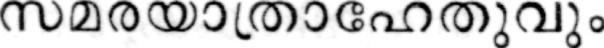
സമരയാത്രാഹേതുവും
